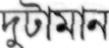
দুটামান
